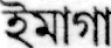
ইমাগা
